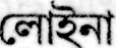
লোইনা
